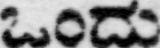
ಒಂದು
